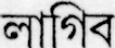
লাগিব
